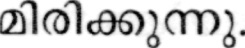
മിരിക്കുന്നു.
